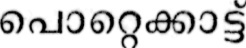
പൊറ്റെക്കാട്ട്
